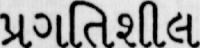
પ્રગતિશીલ
